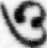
ও
